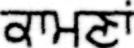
ਕਾਮਣਾਂ
